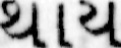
થાય
